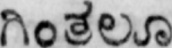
ಗಿಂತಲೂ
